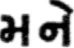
મને
